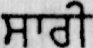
ਸਾਰੀ
